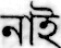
নাই
